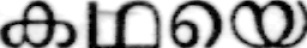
കഥയെ
